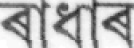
ৰাধাৰ
